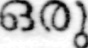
ഒരു
